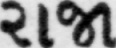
રાજા
